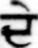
ਦੇ
